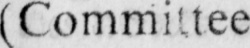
(Commiiltee
